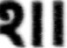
શા
